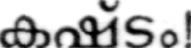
കഷ്ടം!
